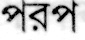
পরপ
